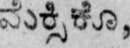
ಮೆಕ್ಸಿಕೊ,
